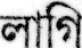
লাগি
